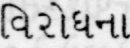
વિરોધના
